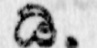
ಡಿ.
